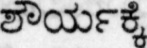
ಶೌರ್ಯಕ್ಕೆ
